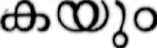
കയും
